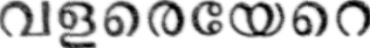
വളരെയേറെ
